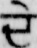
ਦੇ
